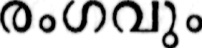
രംഗവും
